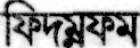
ফিদম্নফম
